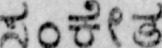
ಸಂಕೇತ
